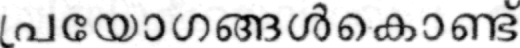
പ്രയോഗങ്ങള്‍കൊണ്ട്
